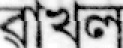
ৱাখল
